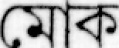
মোক
